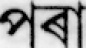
পৰা
